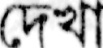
দেখা
